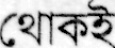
থোকই
